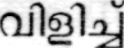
വിളിച്ച്
